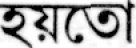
হয়তো
